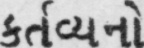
કર્તવ્યનો
